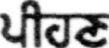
ਪੀਹਣ
